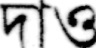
দাও
